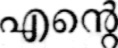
എന്റെ
